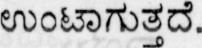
ಉಂಟಾಗುತ್ತದೆ.
